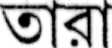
তারা
